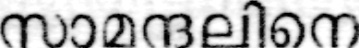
സാമന്ദലിനെ
